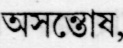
অসন্তোষ,
